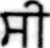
ਸੀ
